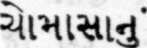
ચોમાસાનું
